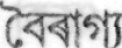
বৈৰাগ্য
